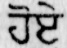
ਹੋਏ
